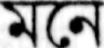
মনে
